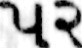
પર
